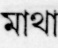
মাথা
